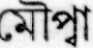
মৌপ্বা
